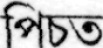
পিচত
